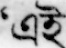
'এই
